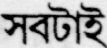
সবটাই
